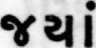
જ્યાં
